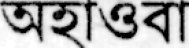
অহাওবা
